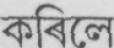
কৰিলে
